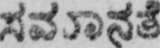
ಸಮಾನತೆ
